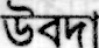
উবদা
